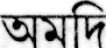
অমদি
